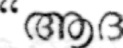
“ആദ
